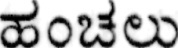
ಹಂಚಲು
